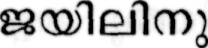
ജയിലിനു
